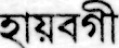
হায়বগী
